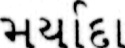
મર્યાદા
